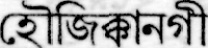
হৌজিক্কানগী
